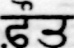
ਫ਼ੌਤ
